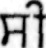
ਸੀ
